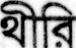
থীরি
